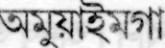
অমুয়াইমগা
